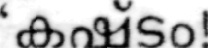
‘കഷ്ടം!
